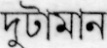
দুটামান
